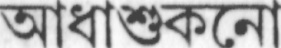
আধাশুকনো
